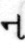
ન
